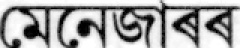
মেনেজাৰৰ
